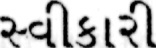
સ્વીકારી
